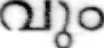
വും
